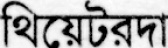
থিয়েটরদা
